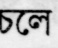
চলে
